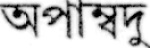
অপাম্বদু
